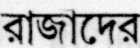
রাজাদের
